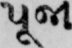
પૂજા
